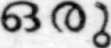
ഒരു
